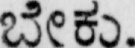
ಬೇಕು.
